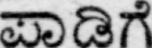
ಪಾಡಿಗೆ
